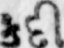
કદી
